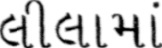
લીલામાં
